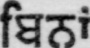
ਬਿਨਾਂ
